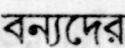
বন্যদের
